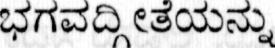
ಭಗವದ್ಗೀತೆಯನ್ನು
